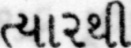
ત્યારથી
